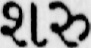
શરુ
